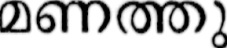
മണത്തു
